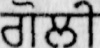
ਗੋਲੀ
